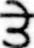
ਤੇ
